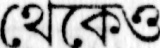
থেকেও
